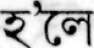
হ'লে
